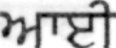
ਆਈ
